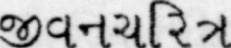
જીવનચરિત્ર
